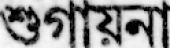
শুগায়না
